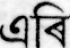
এৰি
